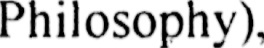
Philosophy),
